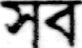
সব
